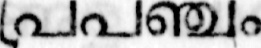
പ്രപഞ്ചം
